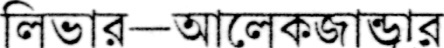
লিভার–আলেকজান্ডার
